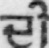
ਦੀ
